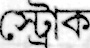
স্ট্রোক
